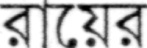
রায়ের
